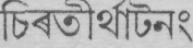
চিৰতীৰ্থাটনং
